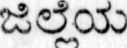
ಜಿಲ್ಲೆಯ
